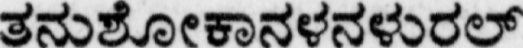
ತನುಶೋಕಾನಳನಳುರಲ್
